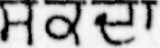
ਸਕਦਾ
